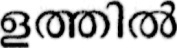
ളത്തില്‍
